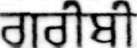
ਗਰੀਬੀ
